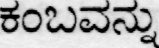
ಕಂಬವನ್ನು
